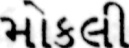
મોકલી
